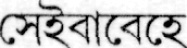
সেইবাবেহে
